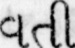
વતી
